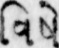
વિષે
